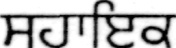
ਸਹਾਇਕ
